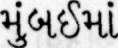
મુંબઈમાં
